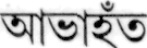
আভাহঁত
